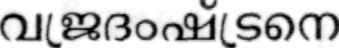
വജ്രദംഷ്ട്രനെ
